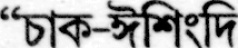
“চাক-ঈশিংদি
